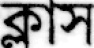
ক্লাস
